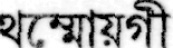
থম্মোয়গী
